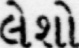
લેશો
